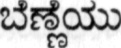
ಬೆಣ್ಣೆಯು
